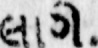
લાગે.
